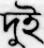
দুই
